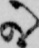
જે
